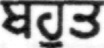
ਬਹੁਤ
